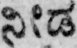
ನೀಡ
